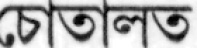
চোতালত
